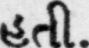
હતી.
